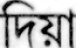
দিয়া
